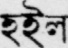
হইল
